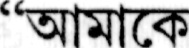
“আমাকে
